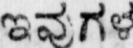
ಇವುಗಳ
